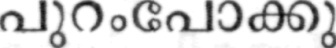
പുറംപോക്കു
